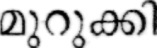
മുറുക്കി
